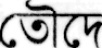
তৌদে
